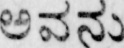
ಅವನು
